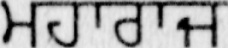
ਮਹਾਰਜ
